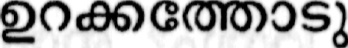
ഉറക്കത്തോടു
